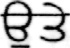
ਉਤੇ
